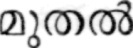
മുതല്‍
